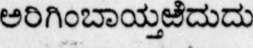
ಅರಿಗಿಂಬಾಯ್ತಱದುದು
